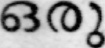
ഒരു
